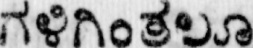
ಗಳಿಗಿಂತಲೂ
